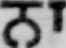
ਨਾ
